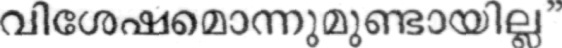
വിശേഷമൊന്നുമുണ്ടായില്ല”
